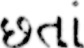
છતાં
